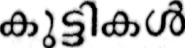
കുട്ടികള്‍
